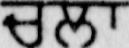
ਚਲਾ
